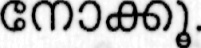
നോക്കൂ.
